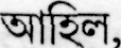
আহিল,
